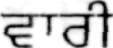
ਵਾਰੀ
